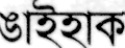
ঙাইহাক
